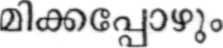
മിക്കപ്പോഴും
